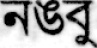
নঙবু
